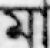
মা
